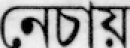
নেচায়
